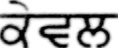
ਕੇਵਲ
